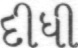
દીધી
